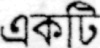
একটি
